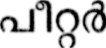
പീറ്റര്‍
